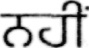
ਨਹੀਂ
